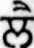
ਲੈ
